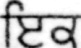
ਇਕ
